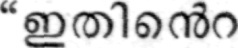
“ഇതിന്റെ
